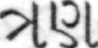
ત્રણ
